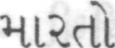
મારતો
